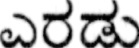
ಎರಡು
